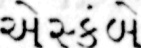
એસ્કંબે
